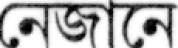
নেজানে
